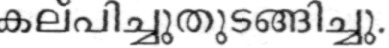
കല്പിച്ചുതുടങ്ങിച്ചു.
